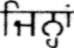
ਜਿਨ੍ਹਾਂ
